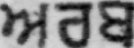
ਅਰਬ
